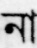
না
